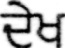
ਦੇਖ
